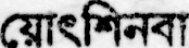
য়োৎশিনবা
